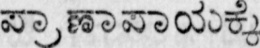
ಪ್ರಾಣಾಪಾಯಕ್ಕೆ
